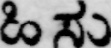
ಹಿಸು
